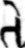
તે
